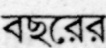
বছরের
